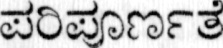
ಪರಿಪೂರ್ಣತೆ
